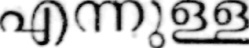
എന്നുള്ള
